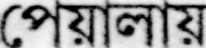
পেয়ালায়
